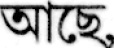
আছে,
